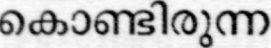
കൊണ്ടിരുന്ന
